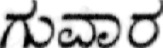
ಗುವಾರ
